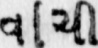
વાંચી
